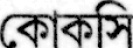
কোকসি
